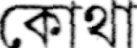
কোথা
